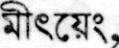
মীৎয়েং,
